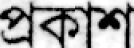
প্রকাশ
